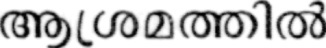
ആശ്രമത്തില്‍
